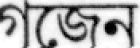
গজেন
